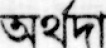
অর্থদা
